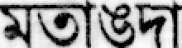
মতাঙদা
